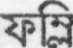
ফম্লি
